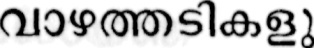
വാഴത്തടികളു
